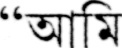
“আমি
